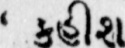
'કહીશ
